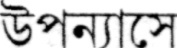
উপন্যাসে
